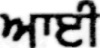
ਆਈ
